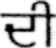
ਦੀ
